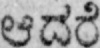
ಆದರೆ
